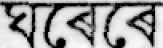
ঘৰেৰে
